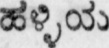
ಹಳ್ಳಿಯ
